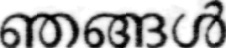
ഞങ്ങള്‍
